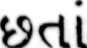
છતાં
